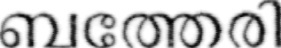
ബത്തേരി
